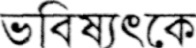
ভবিষ্যত্কে
